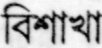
বিশাখা
